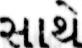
સાથે
